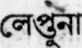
লেপ্তুনা
